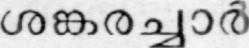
ശങ്കരച്ചാര്‍
